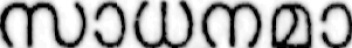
സാധനമാ
